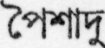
পৈশাদু
